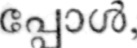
പ്പോള്‍,
